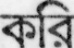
করি
